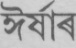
ঈর্ষাৰ
